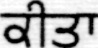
ਕੀਤਾ
